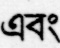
এবং
